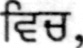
ਵਿਚ,
